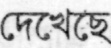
দেখেছে
